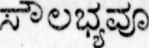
ಸೌಲಭ್ಯವೂ
